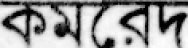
কমরেদ
